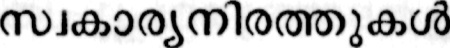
സ്വകാര്യനിരത്തുകള്‍
